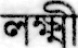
লক্ষ্মী
